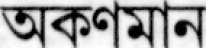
অকণমান
